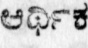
ಆರ್ಥಿಕ
